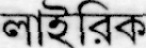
লাইরিক
